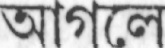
আগলে
